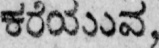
ಕರೆಯುವ,
